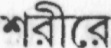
শরীরে
